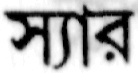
স্যার
